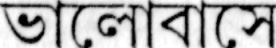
ভালোবাসে
